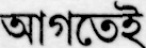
আগতেই
